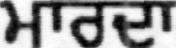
ਮਾਰਦਾ
